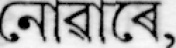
নোৱাৰে,
